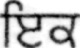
ਇਕ
